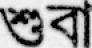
শুবা
